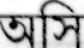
অসি
